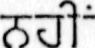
ਨਹੀਂ
